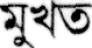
মুখত
